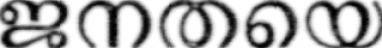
ജനതയെ
